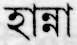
হান্না
